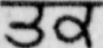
ਤਕ
